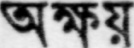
অক্ষয়
